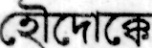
হৌদোক্কে
